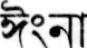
ঈংনা
